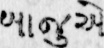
બાજુએ
